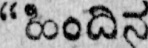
“ಹಿಂದಿನ
